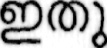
ഇതു
